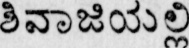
ಶಿವಾಜಿಯಲ್ಲಿ
